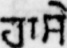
ਹਾਸੇ
